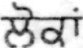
ਲੋਕਾਂ
